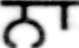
ਨਾ
